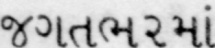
જગતભરમાં
